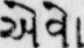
એવો
